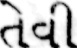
તેવી
